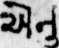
એનુ
